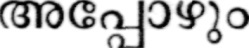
അപ്പോഴും
